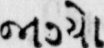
જાગ્યો
